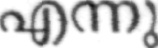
എന്നു
